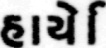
હાર્યો
